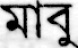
মাবু
